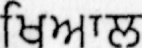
ਖਿਆਲ
